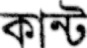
কান্ট
